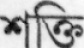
শক্তি
